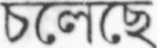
চলেছে
